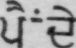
ਪੈਂਦੇ
